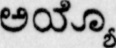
ಅಯ್ಯೊ
